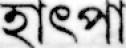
হাৎপা
